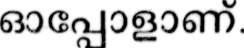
ഓപ്പോളാണ്.
